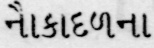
નૌકાદળના
